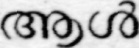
ആള്‍
